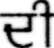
ਦੀ
